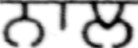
ਨਾਲ
